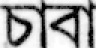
চাবা
